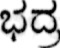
ಭದ್ರ
